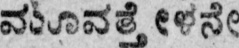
ಮೂವತ್ತೇಳನೇ
